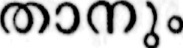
താനും
